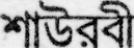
শাউরবী
